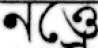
নত্ত্রে
